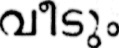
വീടും
